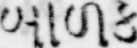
બાળક
